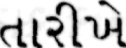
તારીખે
